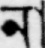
না
